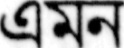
এমন
